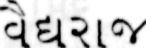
વૈધરાજ
